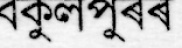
বকুলপুৰৰ
